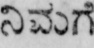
ನಿಮಗೆ
